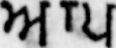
ਆਪ
